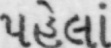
પહેલાં
